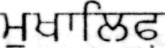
ਮੁਖਾਲਿਫ਼
